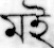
মই
